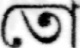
তো
